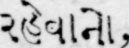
રહેવાનો,
